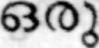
ഒരു
